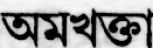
অমখক্তা
